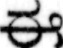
ಈ
